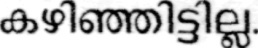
കഴിഞ്ഞിട്ടില്ല.
